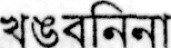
খঙবনিনা
